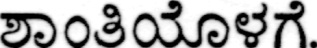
ಶಾಂತಿಯೊಳಗೆ.
